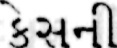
કેસની
